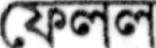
ফেলল
